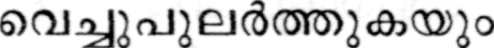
വെച്ചുപുലര്‍ത്തുകയും
